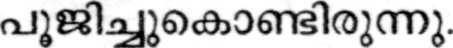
പൂജിച്ചുകൊണ്ടിരുന്നു.
